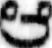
ಆ
